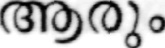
ആരും
